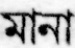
মানা
